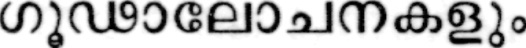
ഗൂഢാലോചനകളും
